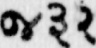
જરૂર
